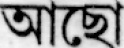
আছো
